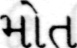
મોત
